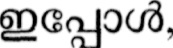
ഇപ്പോള്‍,
